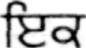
ਇਕ
